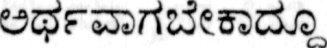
ಅರ್ಥವಾಗಬೇಕಾದ್ದೂ
